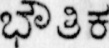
ಭೌತಿಕ
